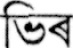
ভিৰ
